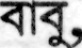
বাবু,
